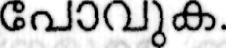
പോവുക.
